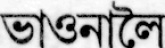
ভাওনালৈ
